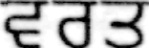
ਵਰਤ
